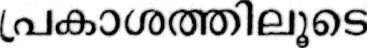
പ്രകാശത്തിലൂടെ
